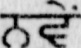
ਨਵੇਂ
